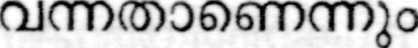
വന്നതാണെന്നും
